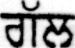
ਗੱਲ
